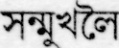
সন্মুখলৈ
